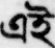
এই
